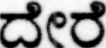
ದೇರೆ
